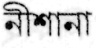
নীশানা
